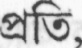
প্রতি,
